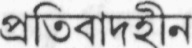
প্রতিবাদহীন
